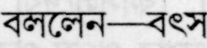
বললেন–বত্স
